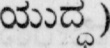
ಯುದ್ಧ)
